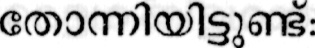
തോന്നിയിട്ടുണ്ട്:
